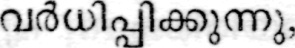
വര്‍ധിപ്പിക്കുന്നു,
